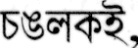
চঙলকই,
